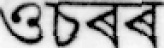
ওচৰৰ
